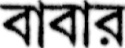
বাবার
